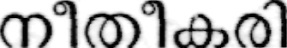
നീതീകരി
